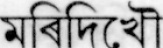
মৰিদিখৌ
